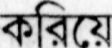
করিয়ে
